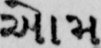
ઓમ
